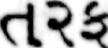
તરફ
